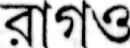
রাগও
